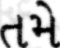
તમે
